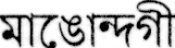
মাঙোন্দগী
